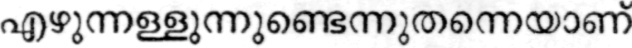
എഴുന്നള്ളുന്നുണ്ടെന്നുതന്നെയാണ്
